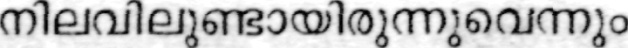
നിലവിലുണ്ടായിരുന്നുവെന്നും
